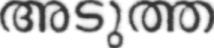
അടുത്ത
